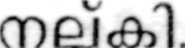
നല്കി.
